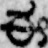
ಈ
